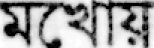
মখোয়
